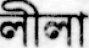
লীলা
